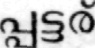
പ്പട്ടര്
